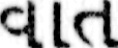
વાત
